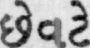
છેવટે
